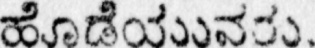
ಹೊಡೆಯುವರು.
